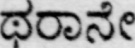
ಥರಾನೇ
